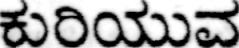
ಕುರಿಯುವ
